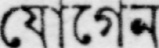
যোগেন
